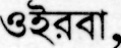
ওইরবা,
